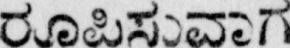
ರೂಪಿಸುವಾಗ
